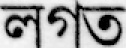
লগত
